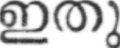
ഇതു
